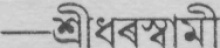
-শ্ৰীধৰস্বামী
